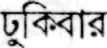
ঢুকিবার
